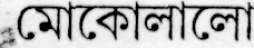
মোকোলালো
